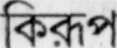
কিরূপ
